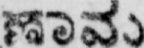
ಣಾಮ
